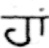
ਹਾਂ
